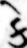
કે
